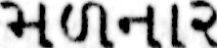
મળનાર
